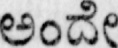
ಅಂದೇ
